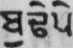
ਬੁਢੇਪੇ
